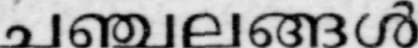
ചഞ്ചലങ്ങള്‍
